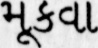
મૂકવા
